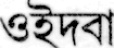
ওইদবা
